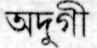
অদুগী
